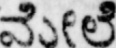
ಮೇಲೆ
